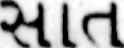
સાત
